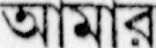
আমার
